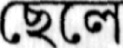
ছেলে
